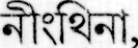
নীংথিনা,
